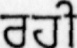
ਰਹੀ
